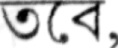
তবে,
